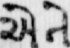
એને
